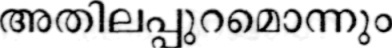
അതിലപ്പുറമൊന്നും
